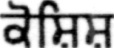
ਕੋਸ਼ਿਸ਼
